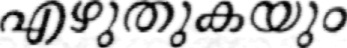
എഴുതുകയും
